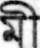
মী
